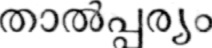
താല്‍പ്പര്യം
